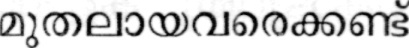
മുതലായവരെക്കണ്ട്
